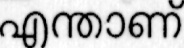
എന്താണ്
